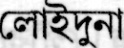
লোইদুনা
